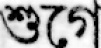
শুগে
